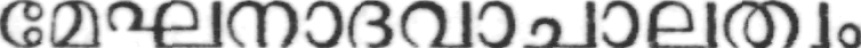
മേഘനാദവാചാലത്വം
